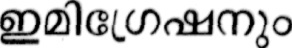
ഇമിഗ്രേഷനും
